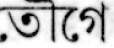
তৌগে
